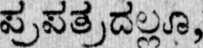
ಪ್ರಪತ್ರದಲ್ಲೂ,
